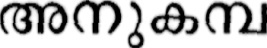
അനുകമ്പ
